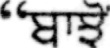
''ਬਾਝੋਂ
